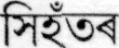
সিহঁতৰ
